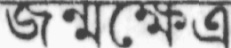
জন্মক্ষেত্র
